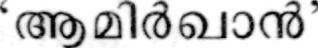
‘ആമിര്‍ഖാന്‍'
